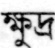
ক্ষুদ্র
